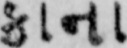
કાના
